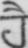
ਹੈ
